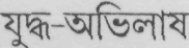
যুদ্ধ-অভিলাষ
